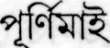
পূর্ণিমাই
